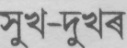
সুখ-দুখৰ
